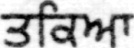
ਤਕਿਆ
